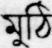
মুঠি
